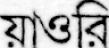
য়াওরি
